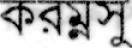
করম্নসু
